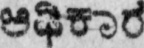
ಅಧಿಕಾರ
